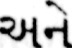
અને
